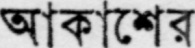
আকাশের
